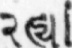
રહ્યાં
